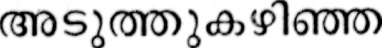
അടുത്തുകഴിഞ്ഞ
